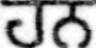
ਹਨ
